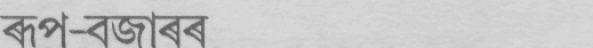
ৰূপ-বজাৰৰ
